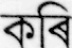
কৰি
